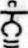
ਨੂੰ
